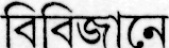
বিবিজানে
